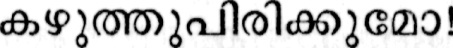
കഴുത്തുപിരിക്കുമോ!
